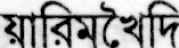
য়ারিমখৈদি
